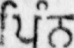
ਪਿੰਨ
